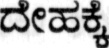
ದೇಹಕ್ಕೆ
